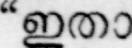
“ഇതാ
